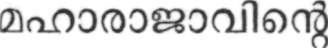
മഹാരാജാവിന്റെ
